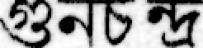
গুনচন্দ্র
